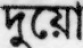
দুয়ো
